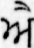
ਐ
